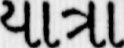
યાત્રા
